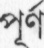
পূর্ণ
